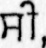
ਸੀ,
